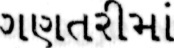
ગણતરીમાં
